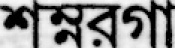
শম্নরগা
